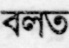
বলত
